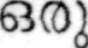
ഒരു
